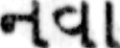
નવા
